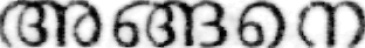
അങ്ങനെ
